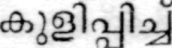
കുളിപ്പിച്ച്
